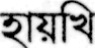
হায়খি
